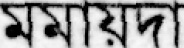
মমায়দা
